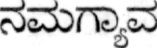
ನಮಗ್ಯಾವ
